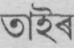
তাইৰ
